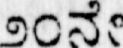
೨೦ನೇ
